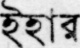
ইহার
